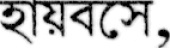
হায়বসে,
